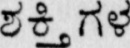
ಶಕ್ತಿಗಳ
